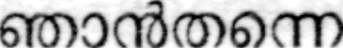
ഞാന്‍തന്നെ
